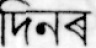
দিনৰ
